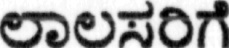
ಲಾಲಸರಿಗೆ
